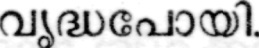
വൃദ്ധപോയി.
